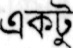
একটু
